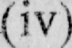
(iv)
